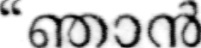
“ഞാന്‍
